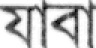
যাবা
